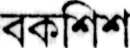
বকশিশ
